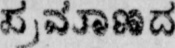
ಪ್ರಮಾಣದ
